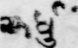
અર્ધું
